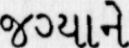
જગ્યાને,
